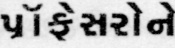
પ્રૉફેસરોને
